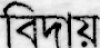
বিদায়
